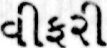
વીફરી
